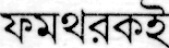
ফমথরকই
